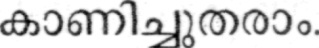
കാണിച്ചുതരാം.
